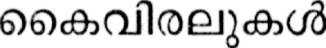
കൈവിരലുകള്‍
